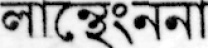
লান্থেংননা
